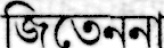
জিতেননা
